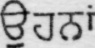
ਉਹਨਾਂ
